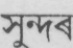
সুন্দৰ
